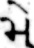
મે
